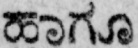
ಹಾಗೂ
